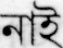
নাই
